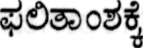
ಫಲಿತಾಂಶಕ್ಕೆ
